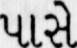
પાસે
